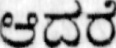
ಆದರೆ
